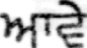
ਆਵੇ
